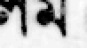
লম
